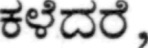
ಕಳೆದರೆ,
